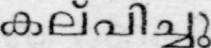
കല്പിച്ചു
